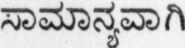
ಸಾಮಾನ್ಯವಾಗಿ
